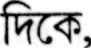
দিকে,
